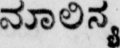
ಮಾಲಿನ್ಯ
